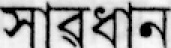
সাৱধান
